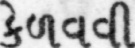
કેળવવી
